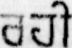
ਰਹੀ
